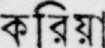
করিয়া
